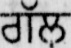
ਗੱਲ
